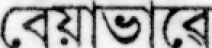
বেয়াভাৱে
